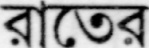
রাতের
